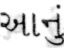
આનું
